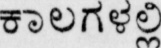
ಕಾಲಗಳಲ್ಲಿ
